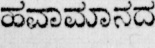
ಹವಾಮಾನದ
